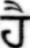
ਹੈ
